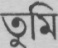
তুমি
